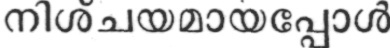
നിശ്ചയമായപ്പോള്‍
